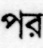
পর
